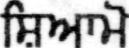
ਸ਼ਿਆਮੋ
